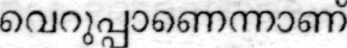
വെറുപ്പാണെന്നാണ്
